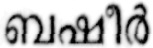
ബഷീര്‍
